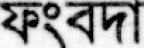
ফংবদা
